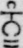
ਨੂੰ
